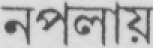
নপলায়
